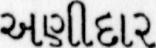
અણીદાર
